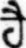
ਹੈ
